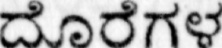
ದೊರೆಗಳ
